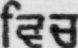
ਵਿਚ
